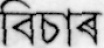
বিচাৰ
